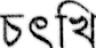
চৎখি
